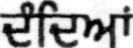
ਦੰਦਿਆਂ
